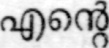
എന്റെ
